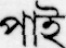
পাই
